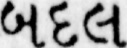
બદલ
